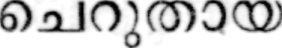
ചെറുതായ
